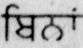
ਬਿਨਾਂ
